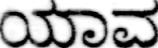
ಯಾವ
